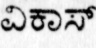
ವಿಕಾಸ್
